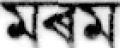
মৰম
